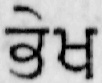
ਭੇਖ
